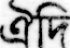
ঐদি
